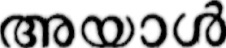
അയാള്‍
